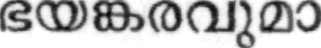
ഭയങ്കരവുമാ
